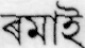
ৰমাই
